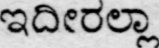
ಇದೀರಲ್ಲಾ
